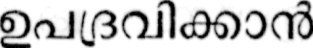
ഉപദ്രവിക്കാന്‍
